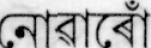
নোৱাৰোঁ
